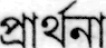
প্ৰাৰ্থনা
